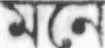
মনে
